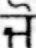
ਜੋ
